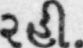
રહી.
